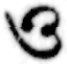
ও
